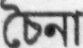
চৈনা
